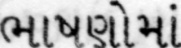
ભાષણોમાં
